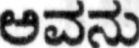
ಅವನು
